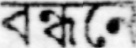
বন্ধনে
